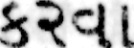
કરવા
